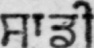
ਸਾਡੀ
